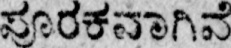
ಪೂರಕವಾಗಿವೆ
